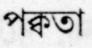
পক্কতা
